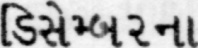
ડિસેમ્બરના
